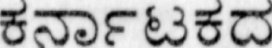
ಕರ್ನಾಟಕದ
